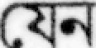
যেন
